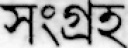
সংগ্রহ
